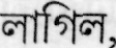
লাগিল,
